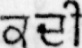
ਕਦੀ
